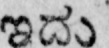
ಇದು
